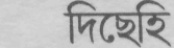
দিছেহি
